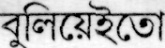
বুলিয়েইতো
